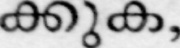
ക്കുക,
